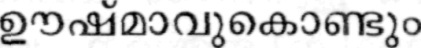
ഊഷ്മാവുകൊണ്ടും
